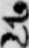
ಸೆ.
